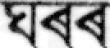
ঘৰৰ
